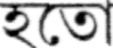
হতো
